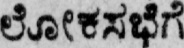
ಲೋಕಸಭೆಗೆ
